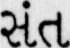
સંત
